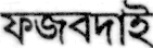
ফজবদাই
